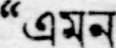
‘‘এমন
